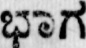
ಭಾಗ
